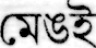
মেঙই
